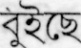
বুইছে
